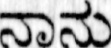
ನಾನು
